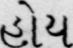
હોય
